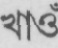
খাওঁ
